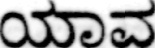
ಯಾವ
